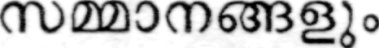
സമ്മാനങ്ങളും
